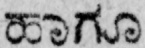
ಹಾಗೂ
